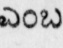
ಎಂಬ
